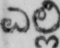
ಎಲ್ಲಿ
